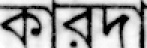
কারদা
